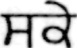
ਸਕੇ
